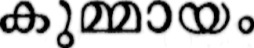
കുമ്മായം
